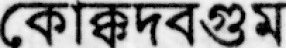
কোক্কদবগুম
